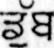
ਡੁੱਬ
